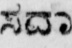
ಸದಾ
